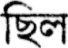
ছিল
